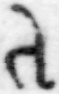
તે
